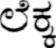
ಲೆಕ್ಕ
